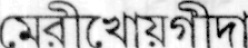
মেরীখোয়গীদা
